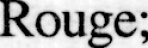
Rouge;
